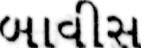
બાવીસ
